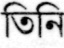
তিনি
